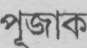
পূজাক
